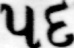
પદ
